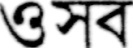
ওসব
